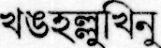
খঙহল্লুখিনু
